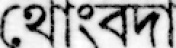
থোংবদা
